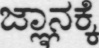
ಜ್ಞಾನಕ್ಕೆ
